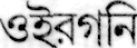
ওইরগনি
